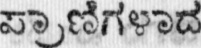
ಪ್ರಾಣಿಗಳಾದ
